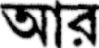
আর
